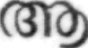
ആ
